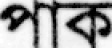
পাক
